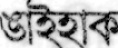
ঙাইহাক
